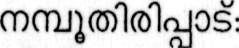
നമ്പൂതിരിപ്പാട്:
